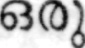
ഒരു
